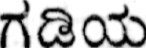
ಗಡಿಯ
